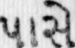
પાસે
